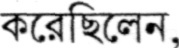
করেছিলেন,
